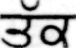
ਤੱਕ
